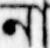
না
